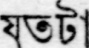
যতটা
